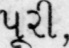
પૂરી,
